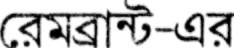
রেমব্রান্ট-এর
